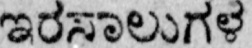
ಇರಸಾಲುಗಳ
